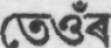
তেওঁৰ
